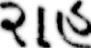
રાહ
